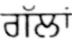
ਗੱਲਾਂ
